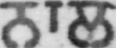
ਨਾਲ
